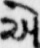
એ
